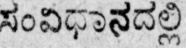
ಸಂವಿಧಾನದಲ್ಲಿ
